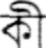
কী
